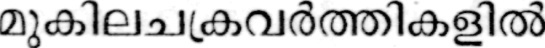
മുകിലചക്രവര്‍ത്തികളില്‍
